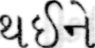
થઈને
